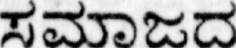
ಸಮಾಜದ
